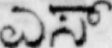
ಎಸ್
